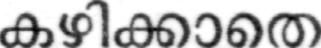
കഴിക്കാതെ
